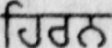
ਹਿਰਨ
